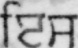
ਇਸ
